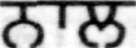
ਨਾਲ
